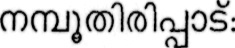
നമ്പൂതിരിപ്പാട്:
